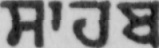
ਸਾਹਬ
